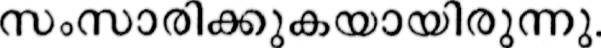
സംസാരിക്കുകയായിരുന്നു.
